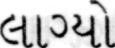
લાગ્યો
